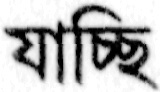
যাচ্ছি
